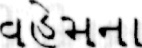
વહેમના
